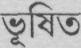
ভূষিত
